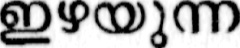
ഇഴയുന്ന
